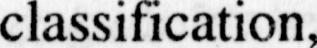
classification,
